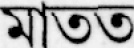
মাতত
